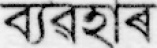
ব্যৱহাৰ
